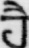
ਹੈ
